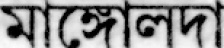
মাঙ্গোলদা
